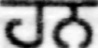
ਹਨ
